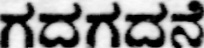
ಗದಗದನೆ
